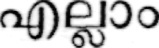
എല്ലാം
